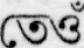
তেওঁ
